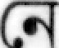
নে
